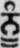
ਨੂੰ
